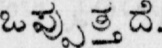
ಒಪ್ಪುತ್ತದೆ.
